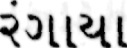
રંગાયા
